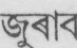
জুৰাব
